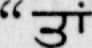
''ਤਾਂ
